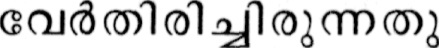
വേര്‍തിരിച്ചിരുന്നതു
